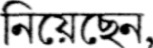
নিয়েছেন,
